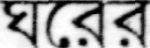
ঘরের
